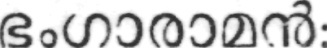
ഭംഗാരാമന്‍:
